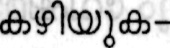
കഴിയുക-
